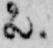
ಪಿ.
